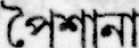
পৈশানা
